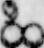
ಹಿ
